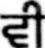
ਵੀ
